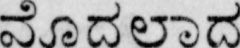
ಮೊದಲಾದ
